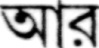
আর
